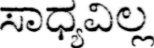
ಸಾಧ್ಯವಿಲ್ಲ
